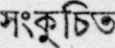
সংকুচিত
